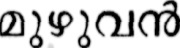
മുഴുവന്‍
